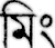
মিং
